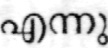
എന്നു
